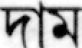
দাম
